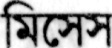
মিসেস
